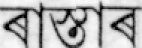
ৰাস্তাৰ
